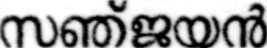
സഞ്ജയന്‍
